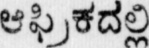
ಆಫ್ರಿಕದಲ್ಲಿ
